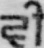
ਵੀ
